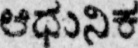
ಆಧುನಿಕ
